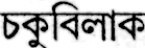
চকুবিলাক
